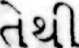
તેથી
